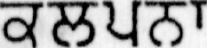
ਕਲਪਨਾ
